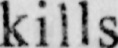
kills
